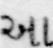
આ
